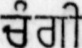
ਚੰਗੀ
